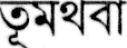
তূমথবা
